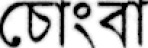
চোংবা
